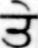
ਤੇ
